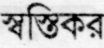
স্বস্তিকর
